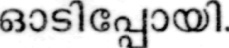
ഓടിപ്പോയി.
